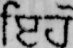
ਇਹੋ
